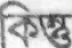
কিন্তু
